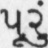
પૂરું
